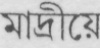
মাদ্ৰীয়ে
